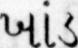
ખાંડ
